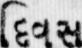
દિવસ
